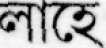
লাহে
